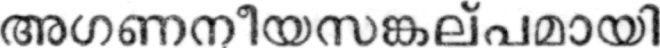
അഗണനീയസങ്കല്പമായി
